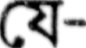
যে-
